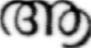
ആ
